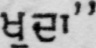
ਖੁਦਾ''
